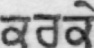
ਕਰਕੇ
